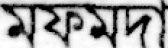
মফমদা
